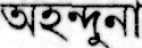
অহন্দুনা
